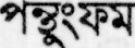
পন্থুংফম
